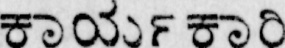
ಕಾರ್ಯಕಾರಿ
